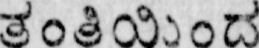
ತಂತಿಯಿಂದ
